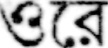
ওরে
